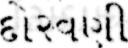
દોરવણી
